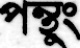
পন্থুং
